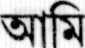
আমি
